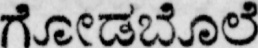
ಗೋಡಬೊಲೆ
